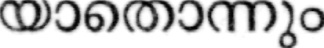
യാതൊന്നും
